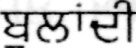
ਬੁਲਾਂਦੀ
